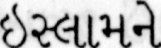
ઇસ્લામને
